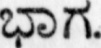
ಭಾಗ.
